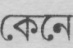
কেনে
